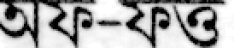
অফ-ফত্ত
